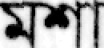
মশা
